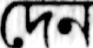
দেন
